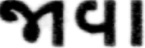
જાવા
